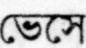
ভেসে
